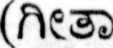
(ಗೀತಾ
